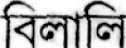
বিলালি
